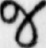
જ
